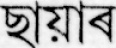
ছায়াৰ
